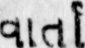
વાર્તા
